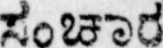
ಸಂಚಾರ
